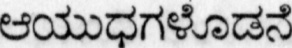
ಆಯುಧಗಳೊಡನೆ
